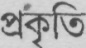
প্ৰকৃতি
